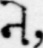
ને,
